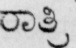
ರಾತ್ರಿ
